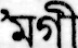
’মগী
